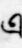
এ
